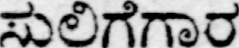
ಸುಲಿಗೆಗಾರ
